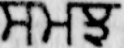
ਸਮਝ
